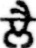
ਲੈ
